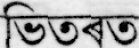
ভিতৰত
